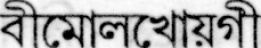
বীমোলখোয়গী
